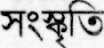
সংস্কৃতি
